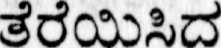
ತೆರೆಯಿಸಿದ
